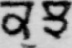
ਕੁਝ
